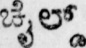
ಚೈಲ್ಡ್
